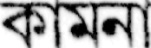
কামনা
